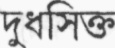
দুধসিক্ত
